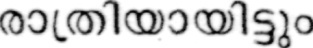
രാത്രിയായിട്ടും
